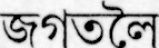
জগতলৈ
